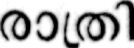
രാത്രി
